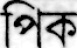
পিক
